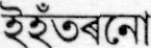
ইহঁতৰনো
